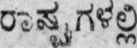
ರಾಷ್ಟ್ರಗಳಲ್ಲಿ
